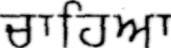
ਚਾਹਿਆ
